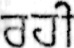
ਰਹੀ
